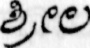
ಶ್ರೀಲ
